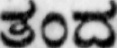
ತಂದ
